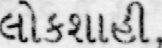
લોકશાહી,
